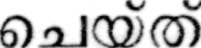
ചെയ്ത്
